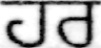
ਹਰ
